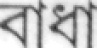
বাধা
